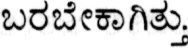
ಬರಬೇಕಾಗಿತ್ತು.
